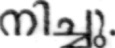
നിച്ചു.
